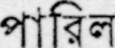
পারিল
